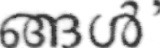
ങ്ങള്‍'
